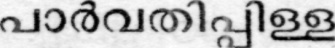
പാര്‍വതിപ്പിള്ള
